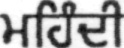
ਮਹਿੰਦੀ
